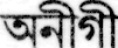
অনীগী
